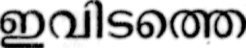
ഇവിടത്തെ
